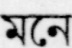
মনে
